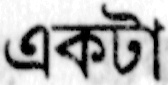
একটা
